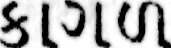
કાગળ
